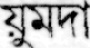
য়ুমদা
